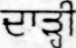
ਦਾੜ੍ਹੀ
